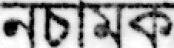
নচামক
